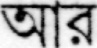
আর
